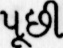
પૂછી
